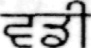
ਵਡੀ
